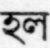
হল
